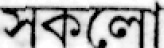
সকলো
